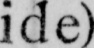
ide)
